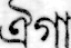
ঐগা
